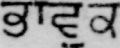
ਭਾਵੁਕ
